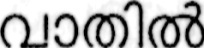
വാതില്‍
